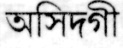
অসিদগী
